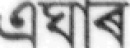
এঘাৰ
